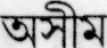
অসীম
